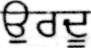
ਉਰਦੂ
